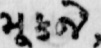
મૂકજે,
